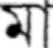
মা
